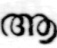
ആ
